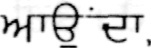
ਆਉਂਦਾ,
